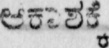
ಆಕಾಶಕ್ಕೆ
